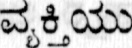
ವ್ಯಕ್ತಿಯು
